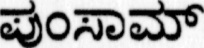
ಪುಂಸಾಮ್
